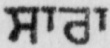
ਸਾਰਾ
